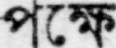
পক্ষে
